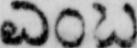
ಎಂಬ
